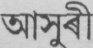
আসুৰী
